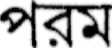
পরম
